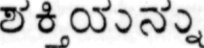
ಶಕ್ತಿಯನ್ನು
